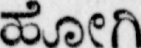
ಹೋಗಿ
